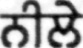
ਨੀਲੇ
